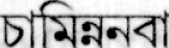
চামিন্ননবা
